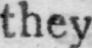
they
